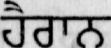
ਹੈਰਾਨ
